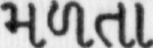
મળતા
